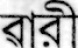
ৱারী
